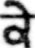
ਕੇ
